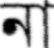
না
